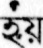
হয়
